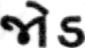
જોડ
